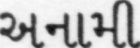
અનામી
